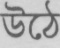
উঠে
